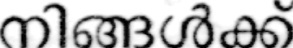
നിങ്ങള്‍ക്ക്
